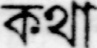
কথা
